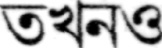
তখনও
